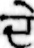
ਦੇ
